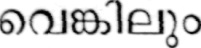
വെങ്കിലും
